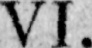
VI.
